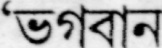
‘ভগবান
